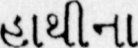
હાથીના
